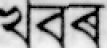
খবৰ
